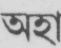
অহা
